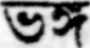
ভঙ্গ
